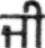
ਜੀ
